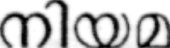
നിയമ
